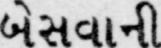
બેસવાની
